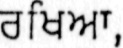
ਰਖਿਆ,
